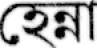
হেন্না
